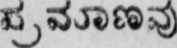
ಪ್ರಮಾಣವು
